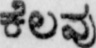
ಕೆಲವು
